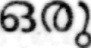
ഒരു
